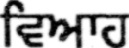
ਵਿਆਹ
